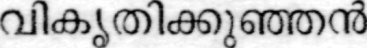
വികൃതിക്കുഞ്ഞന്‍
